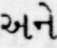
અને
